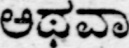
ಅಥವಾ
